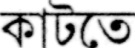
কাটতে
